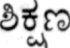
ಶಿಕ್ಷಣ
